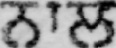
ਨਾਲ
